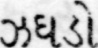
ઝઘડો
